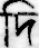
দি
